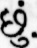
છું.
